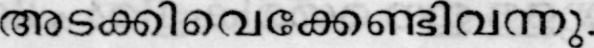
അടക്കിവെക്കേണ്ടിവന്നു.
